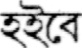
হইবে
